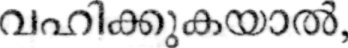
വഹിക്കുകയാല്‍,
